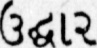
ઉદ્ધાર
